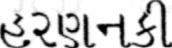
હરણનકી
